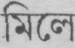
মিলে
